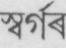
স্বৰ্গৰ
